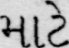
માટે
